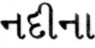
નદીના
